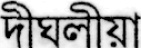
দীঘলীয়া
